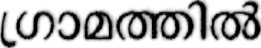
ഗ്രാമത്തില്‍
